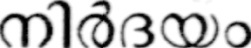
നിര്‍ദയം
